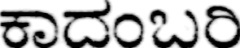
ಕಾದಂಬರಿ
